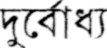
দুর্বোধ্য
